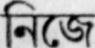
নিজে
